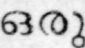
ഒരു
